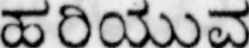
ಹರಿಯುವ
